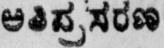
ಅತಿಪ್ರಸರಣ
